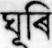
ঘূৰি
